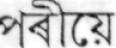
পৰীয়ে
